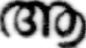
ആ
